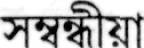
সম্বন্ধীয়া
